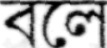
বলে
